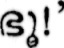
ഭൂ!’
